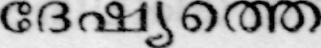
ദേഷ്യത്തെ
